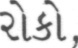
રોકો,
